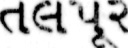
તલપૂર
